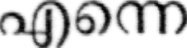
എന്നെ
